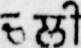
ਚਲੀ
